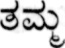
ತಮ್ಮ
